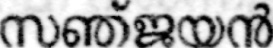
സഞ്ജയന്‍
